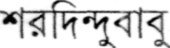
শরদিন্দুবাবু
